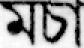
মচা
